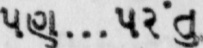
પણ...પરંતુ
